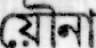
য়ৌনা
